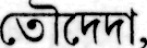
তৌদেদা,
